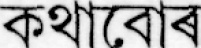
কথাবোৰ
